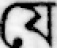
যে
